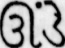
ઊંડે
